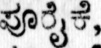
ಪೂರೈಕೆ,
